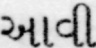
આવી
